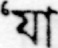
‘যা
